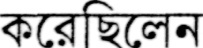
করেছিলেন
